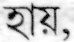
হায়,
